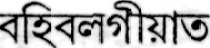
বহিবলগীয়াত
